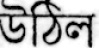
উঠিল
